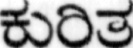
ಕುರಿತ
